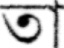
তা
